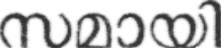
സമായി
